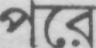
পরে
